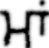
ਮਾਂ
